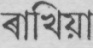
ৰাখিয়া
